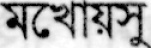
মখোয়সু
